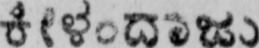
ಕೀಳಂದಾಜು
